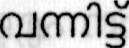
വന്നിട്ട്
